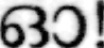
ഓ!
